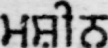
ਮਸ਼ੀਨ
